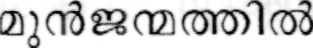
മുന്‍ജന്മത്തില്‍
